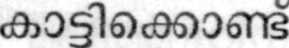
കാട്ടിക്കൊണ്ട്
